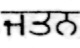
ਜਤਨ
